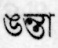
ঙন্তা
